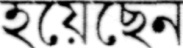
হয়েছেন
